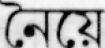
নৈয়ে
